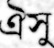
ঐসু
